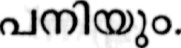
പനിയും.
